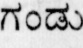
ಗಂಡು
